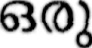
ഒരു
